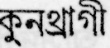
কুনথ্রাগী
